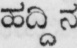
ಹದ್ದಿನ
